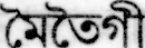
মৈতৈগী
